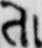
તો
